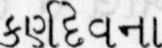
કર્ણદેવના
